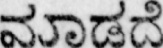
ಮಾಡದೆ
